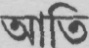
আতি
